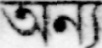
অন্য
